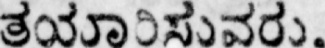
ತಯಾರಿಸುವರು.
